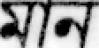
মান
